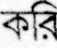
করি
